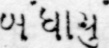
બંધાયું
